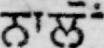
ਨਾਲੋਂ
